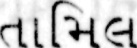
તામિલ
